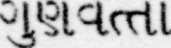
ગુણવત્તા
